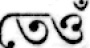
তেওঁ
